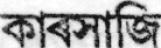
কাৰসাজি
